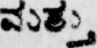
ಮತ್ತು
